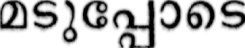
മടുപ്പോടെ
